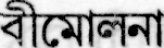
বীমোলনা
